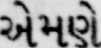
એમણે
